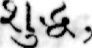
શુદ્ધ,
